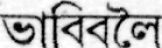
ভাবিবলৈ
